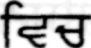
ਵਿਚ
